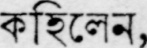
কহিলেন,
